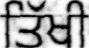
ਤਿੱਖੀ
